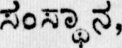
ಸಂಸ್ಥಾನ,
